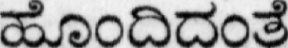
ಹೊಂದಿದಂತೆ
